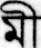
মী
